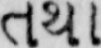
તથા
